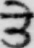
ਤੇ
